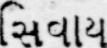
સિવાય
